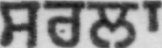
ਸਰਲਾ
